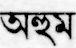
অহুম
